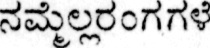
ನಮ್ಮೆಲ್ಲರಂಗಗಳೆ
